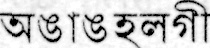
অঙাঙহলগী
